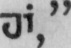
ਹਾਂ,''
